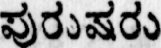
ಪುರುಷರು
